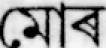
মোৰ
